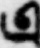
এ
